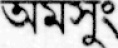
অমসুং
